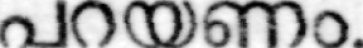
പറയണം.
